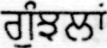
ਗੁੰਝਲਾਂ
